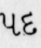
પદ
